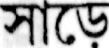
সাড়ে
